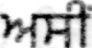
ਅਸੀਂ
